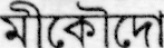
মীকৌদো
